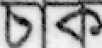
চাক
